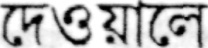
দেওয়ালে
